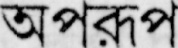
অপরূপ
